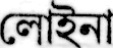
লোইনা
